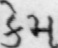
કેમ
